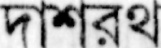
দাশরথ
